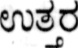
ಉತ್ತರ
